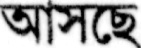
আসছে
